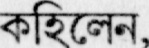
কহিলেন,
